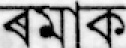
ৰমাক
